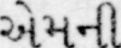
એમની
